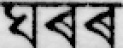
ঘৰৰ
